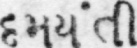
દમયંતી
